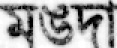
মঙদা
